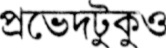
প্রভেদটুকুও
